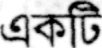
একটি
